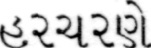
હરચરણે
